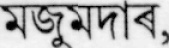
মজুমদাৰ,
